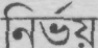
নিৰ্ভয়
